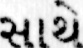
સાથે
